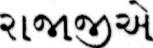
રાજાજીએ
